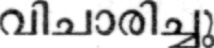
വിചാരിച്ചു
